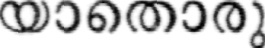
യാതൊരു
